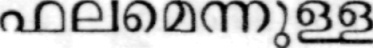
ഫലമെന്നുള്ള
